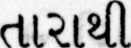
તારાથી
